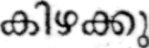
കിഴക്കു
